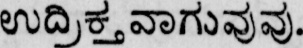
ಉದ್ರಿಕ್ತವಾಗುವುವು.
